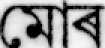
মোৰ
